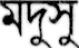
মদুসু
